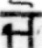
ਜੋ
